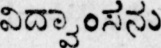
ವಿದ್ವಾಂಸನು
